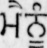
ਮੈਨੂੰ
